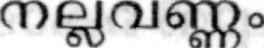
നല്ലവണ്ണം
